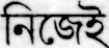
নিজেই
